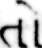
તો
